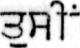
ਤੁਸੀਂ
